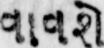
વાવશે
